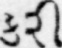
કરી
